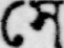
সে
